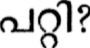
പറ്റി?
